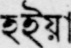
হইয়া
